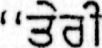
''ਤੇਰੀ
